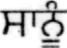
ਸਾਨੂੰ
